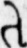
તે
